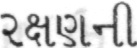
રક્ષણની
